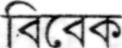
বিবেক
